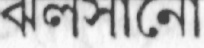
ঝলসানো
